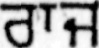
ਰਾਜ
